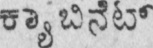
ಕ್ಯಾಬಿನೆಟ್
